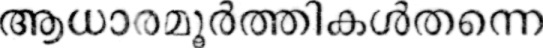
ആധാരമൂര്‍ത്തികള്‍തന്നെ
